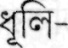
ধূলি-
